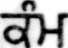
ਕੰਮ
